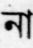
না
